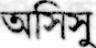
অসিবু
